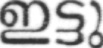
ഇട്ടു
